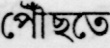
পৌঁছতে
